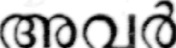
അവര്‍
